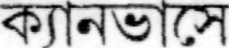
ক্যানভাসে
